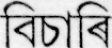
বিচাৰি
